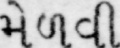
મેળવી
